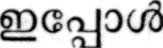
ഇപ്പോള്‍
